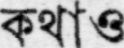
কথাও
